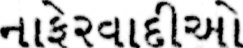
નાફેરવાદીઓ
